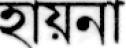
হায়না
